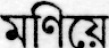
মণিয়ে
